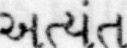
અત્યંત
